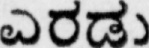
ಎರಡು
